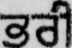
ਭਰੀ
